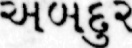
અબદુર
